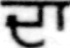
ਦਾ
